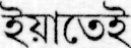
ইয়াতেই
